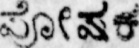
ಪೋಷಕ
